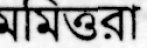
মমিত্তরা
